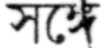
সঙ্গে
